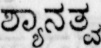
ಶ್ಯಾನತ್ವ
